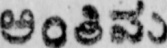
ಅಂತಿಮ
